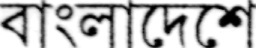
বাংলাদেশে
